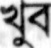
খুব
